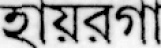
হায়রগা
